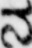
ನ
